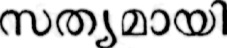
സത്യമായി
